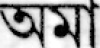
অমা
